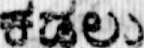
ಕಡಲು
